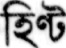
হিণ্ট
